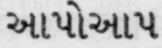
આપોઆપ
